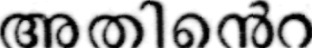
അതിന്റെ
